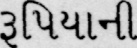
રૂપિયાની
